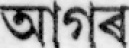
আগৰ
